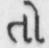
તો
